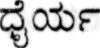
ಧೈರ್ಯ
